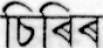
চিৰিৰ
